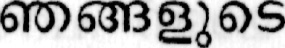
ഞങ്ങളുടെ
